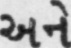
અને
